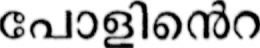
പോളിന്റെ
